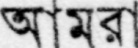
আমরা
